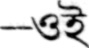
-ওই
